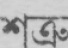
শত্ৰু
